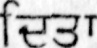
ਦਿਤਾ
